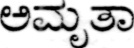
ಅಮೃತಾ
